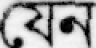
যেন
